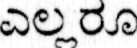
ಎಲ್ಲರೂ
